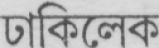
ঢাকিলেক
